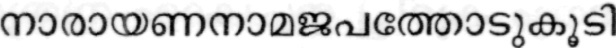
നാരായണനാമജപത്തോടുകൂടി
